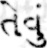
તેવું
